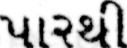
પારથી
